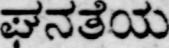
ಘನತೆಯ
